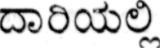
ದಾರಿಯಲ್ಲಿ
